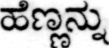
ಹೆಣ್ಣನ್ನು
